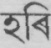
হৰি
